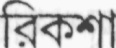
রিকশা
